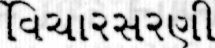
વિચારસરણી
